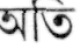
অতি
